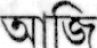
আজি
